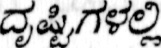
ದೃಷ್ಟಿಗಳಲ್ಲಿ
